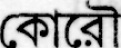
কোরৌ
